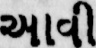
આવી
